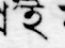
প্র'ই
